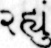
રહ્યું
